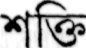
শক্তি
